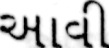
આવી
